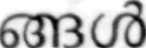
ങ്ങള്‍
